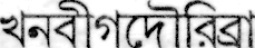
খনবীগদৌরিব্রা
